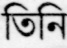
তিনি
